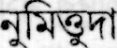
নুমিত্তুদা
